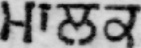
ਮਾਲਕ
